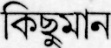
কিছুমান
